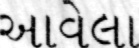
આવેલા
